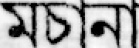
মচানা
